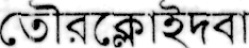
তৌরক্লোইদবা
